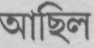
আছিল
